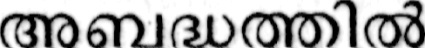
അബദ്ധത്തില്‍
